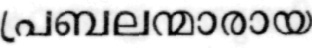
പ്രബലന്മാരായ
